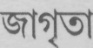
জাগৃতা
